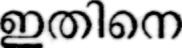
ഇതിനെ
